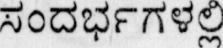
ಸಂದರ್ಭಗಳಲ್ಲಿ
